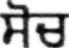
ਸੋਚ
